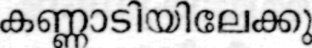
കണ്ണാടിയിലേക്കു
